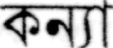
কন্যা
